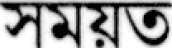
সময়ত
